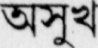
অসুখ
